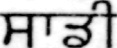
ਸਾਡੀ
